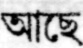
আছে
